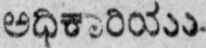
ಅಧಿಕಾರಿಯು
